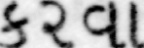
કરવા
